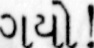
ગયો!
